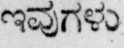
ಇವುಗಳು
